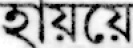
হায়য়ে
